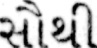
સૌથી
